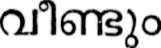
വീണ്ടും
